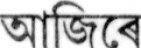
আজিৰে
